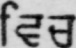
ਵਿਚ
